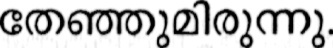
തേഞ്ഞുമിരുന്നു.
